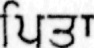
ਪਿਤਾ
